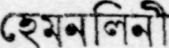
হেমনলিনী
